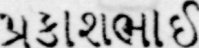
પ્રકાશભાઈ
